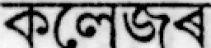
কলেজৰ
